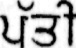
ਪੱਤੀ
